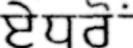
ਏਧਰੋਂ
